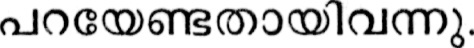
പറയേണ്ടതായിവന്നു.
